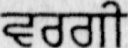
ਵਰਗੀ
